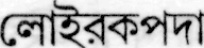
লোইরকপদা
